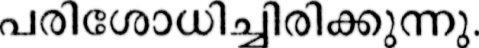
പരിശോധിച്ചിരിക്കുന്നു.
